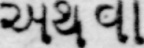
અથવા
